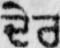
ਦੇਰ
